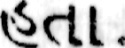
હતા.
